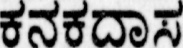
ಕನಕದಾಸ
